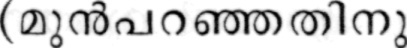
(മുന്‍പറഞ്ഞതിനു
